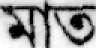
মাত
